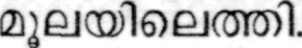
മൂലയിലെത്തി.
